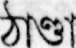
ঠাণ্ডা
